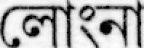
লোংনা
